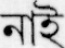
নাই
